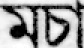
মচা
